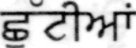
ਛੁੱਟੀਆਂ
